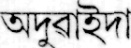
অদুৱাইদা
